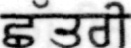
ਛੱਤਰੀ
